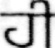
ਹੀ
